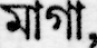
মাগা,
